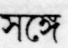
সঙ্গে
